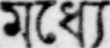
মধ্যে
